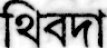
থিবদা
